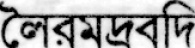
লৈরমদ্রবদি
